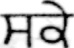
ਸਕੇ
